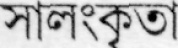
সালংকৃতা
